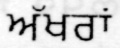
ਅੱਖਰਾਂ
